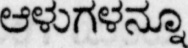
ಆಳುಗಳನ್ನೂ
